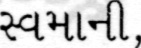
સ્વમાની,
